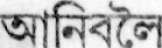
আনিবলৈ
